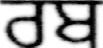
ਰਬ
